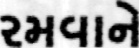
રમવાને
